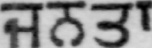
ਜਨਤਾ
